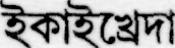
ইকাইখ্রেদা
